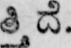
ತ್ತಿದೆ.
